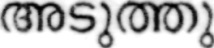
അടുത്തു
